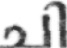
ചി
